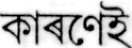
কাৰণেই
